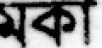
মকা
